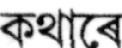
কথাৰে
